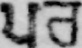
ਪਰ
